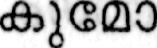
കുമോ
